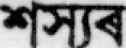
শস্যৰ
